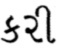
કરી
